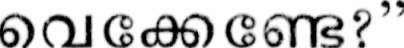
വെക്കേണ്ടേ?”
